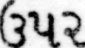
ઉપર
